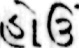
હોઉં
